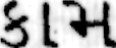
કામ
